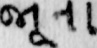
જૂના
